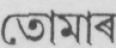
তোমাৰ
